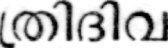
ത്രിദിവ
